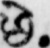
છે.
